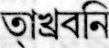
তাখ্রবনি
